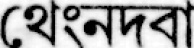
থেংনদবা
